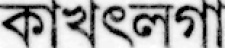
কাখৎলগা
